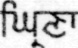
ਘ੍ਰਿਣਾ
